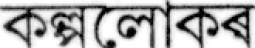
কল্পলোকৰ
